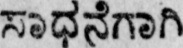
ಸಾಧನೆಗಾಗಿ
